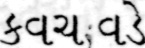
કવચઃવડે
